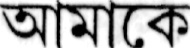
আমাকে
